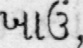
ખાઉં,
